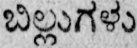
ಬಿಲ್ಲುಗಳು
